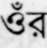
ওঁর
